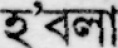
হ'বলা
